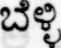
ಬೆಳ್ಳಿ
